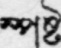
স্পষ্ট
